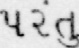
પરંતુ
